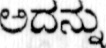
ಅದನ್ನು
